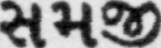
સમજી
